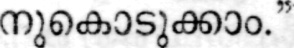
നുകൊടുക്കാം."
